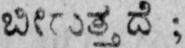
ಬೀರುತ್ತದೆ:
